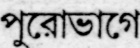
পুরোভাগে
